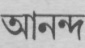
আনন্দ
